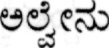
ಅಲ್ವೇನು
